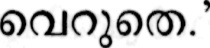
വെറുതെ.'
